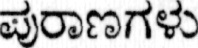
ಪುರಾಣಗಳು
